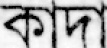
কাদা
